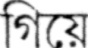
গিয়ে
